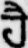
ਹੈ
